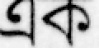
এক
